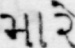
મારે
